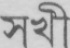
সখী
